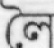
লৈ
